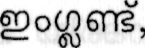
ഇംഗ്ലണ്ട്,
